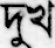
দুখ
